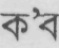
ক'ব
